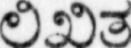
ಲಿಖಿತ
